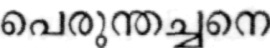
പെരുന്തച്ചനെ
